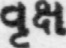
વૃક્ષ
